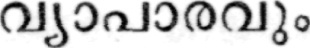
വ്യാപാരവും
